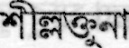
শীল্লক্তুনা
